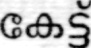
കേട്ട്
